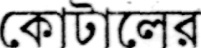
কোটালের
